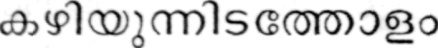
കഴിയുന്നിടത്തോളം
